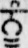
ਨੂੰ
